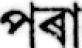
পৰা
